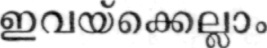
ഇവയ്ക്കെല്ലാം
